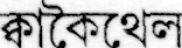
ক্বাকৈথেল
